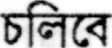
চলিবে
